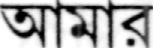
আমার
